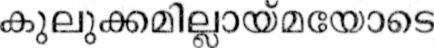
കുലുക്കമില്ലായ്മയോടെ
